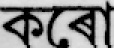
কৰো
